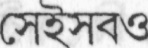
সেইসবও
